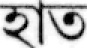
হাত
